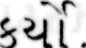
કર્યો.
